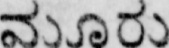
ಮೂರು
